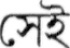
সেই
